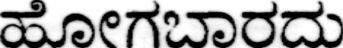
ಹೋಗಬಾರದು
